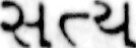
સત્ય
